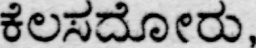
ಕೆಲಸದೋರು,
